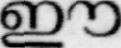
ഈ
